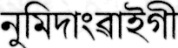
নুমিদাংৱাইগী
